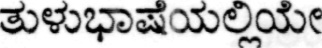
ತುಳುಭಾಷೆಯಲ್ಲಿಯೇ
